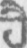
ਹੈ
